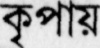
কৃপায়
